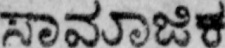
ಸಾಮಾಜಿಕ
